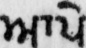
ਆਪੇ
